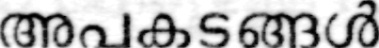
അപകടങ്ങള്‍
